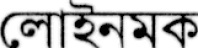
লোইনমক
